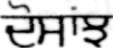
ਦੋਸਾਂਝ
